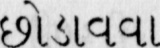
છોડાવવા
